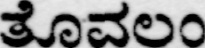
ತೊವಲಂ
